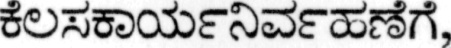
ಕೆಲಸಕಾರ್ಯನಿರ್ವಹಣೆಗೆ,
